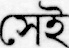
সেই
